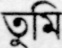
তুমি
